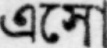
এসো
